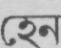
হেন
